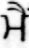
ਮੈਂ
